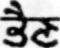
ਭੈਣ
